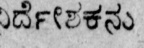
ನಿರ್ದೇಶಕನು
